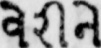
વેરીને
